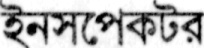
ইনসপেকটর
